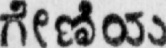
ಗೇಣಿಯ
